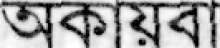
অকায়বা
